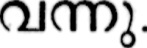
വന്നു.
